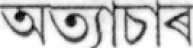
অত্যাচাৰ
